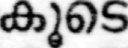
കൂടെ
